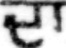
ਦਾ
